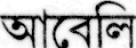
আবেলি
